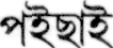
পইছাই
